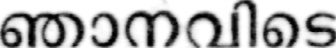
ഞാനവിടെ
